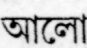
আলো
